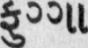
ફુગ્ગા
